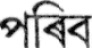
পৰিব
